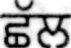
ਛੱਲ
